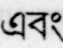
এবং
